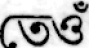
তেওঁ
